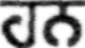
ਹਨ
